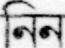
নিন
